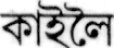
কাইলৈ
